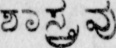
ಶಾಸ್ತ್ರವು
